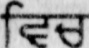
ਵਿਚ
